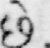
છે.
